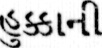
હુક્કાની
